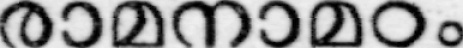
രാമനാമഠം
